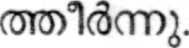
ത്തീര്‍ന്നു.
